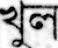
খুল
